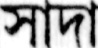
সাদা
